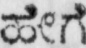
ಹೇಗೆ
